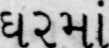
ઘરમાં
